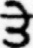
ਤੇ
